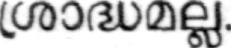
ശ്രാദ്ധമല്ല.
